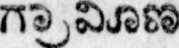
ಗ್ರಾಮೀಣ
